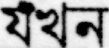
যখন
